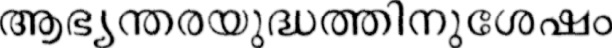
ആഭ്യന്തരയുദ്ധത്തിനുശേഷം
